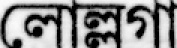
লোল্লগা
